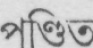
পণ্ডিত
